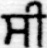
ਸੀ
